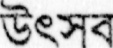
উত্সব
